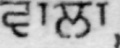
ਵਾਲਾ,
